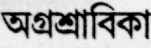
অগ্রশ্রাবিকা
